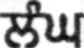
ਲੰਘ
